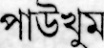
পাউখুম
